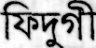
ফিদুগী
